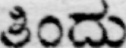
ತಿಂದು
